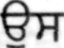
ਉਸ
